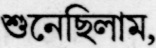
শুনেছিলাম,
